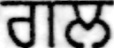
ਗਲ
